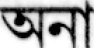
অনা
